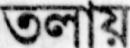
তলায়
